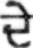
ਦੇ
